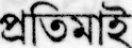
প্রতিমাই
